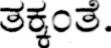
ತಕ್ಕಂತೆ.
